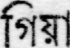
গিয়া
